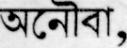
অনৌবা,
